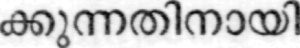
ക്കുന്നതിനായി
